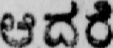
ಆದರೆ
